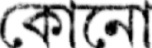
কোনো
